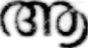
ആ
